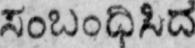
ಸಂಬಂಧಿಸಿದ
